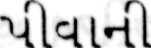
પીવાની
